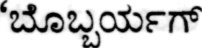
'ಬೊಬ್ಬರ್ಯಗ್
